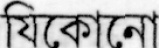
যিকোনো
